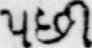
પછી
